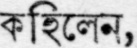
কহিলেন,
